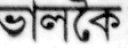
ভালকৈ
